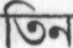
তিন
